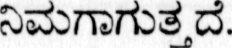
ನಿಮಗಾಗುತ್ತದೆ.
